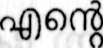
എന്റെ
